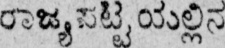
ರಾಜ್ಯಪಟ್ಟಿಯಲ್ಲಿನ
